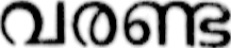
വരണ്ട
